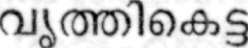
വൃത്തികെട്ട
